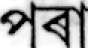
পৰা
